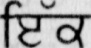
ਇੱਕ
